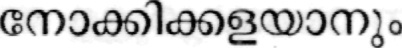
നോക്കിക്കളയാനും
